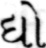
દ્યો
